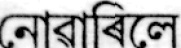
নোৱাৰিলে
